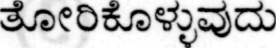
ತೋರಿಕೊಳ್ಳುವುದು
